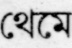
থেমে
